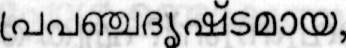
പ്രപഞ്ചദൃഷ്ടമായ,
